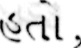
હતો,
